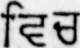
ਵਿਚ
